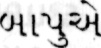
બાપુએ
